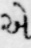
એ
